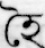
হৈ
